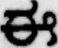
ಈ
